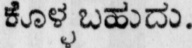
ಕೊಳ್ಳಬಹುದು.
